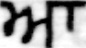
ਆ
